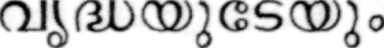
വൃദ്ധയുടേയും
